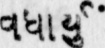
વધાર્યું
